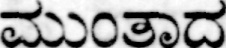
ಮುಂತಾದ
